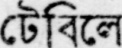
টেবিলে
